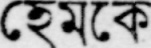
হেমকে
